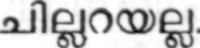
ചില്ലറയല്ല.
